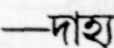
–দাহ্য
